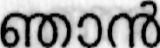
ഞാന്‍
